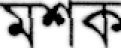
মশক
